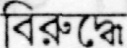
বিরুদ্ধে
